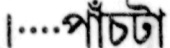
৷....পাঁচটা
